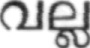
വല്ല
